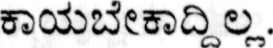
ಕಾಯಬೇಕಾದ್ದಿಲ್ಲ.
